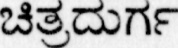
ಚಿತ್ರದುರ್ಗ
